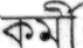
কৰ্মী
